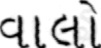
વાલો
